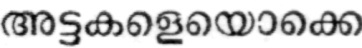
അട്ടകളെയൊക്കെ
